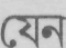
যেন
